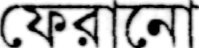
ফেরানো
